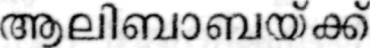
ആലിബാബയ്ക്ക്
